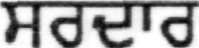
ਸਰਦਾਰ
